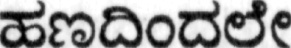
ಹಣದಿಂದಲೇ
